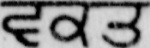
ਵਕਤ
